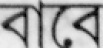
বাবে
